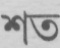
শত
